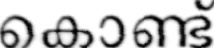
കൊണ്ട്
